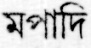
মপাদি
